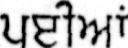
ਪਈਆਂ
